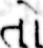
તો
